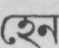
হেন
